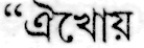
“ঐখোয়
